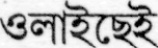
ওলাইছেই
